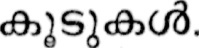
കൂടുകള്‍.
